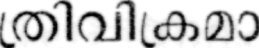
ത്രിവിക്രമാ
